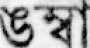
ঙম্বা
